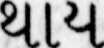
થાય
